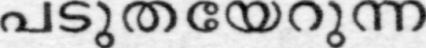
പടുതയേറുന്ന
